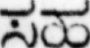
ಸಹ
